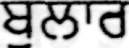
ਬੁਲਾਰ
